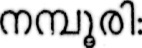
നമ്പൂരി:
